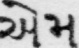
એમ
